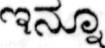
ಇನ್ನೂ
